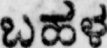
ಬಹಳ
